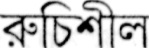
রুচিশীল
